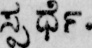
ಸ್ಪರ್ಧೆ.
